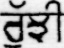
ਰੁੱਝੀ
